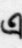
এ
